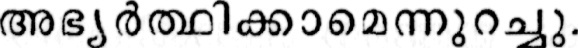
അഭ്യര്‍ത്ഥിക്കാമെന്നുറച്ചു.
